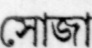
সোজা
